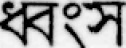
ধ্বংস
